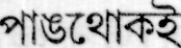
পাঙথোকই
